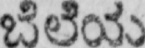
ಬೆಲೆಯ
